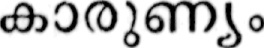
കാരുണ്യം
